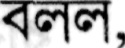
বলল,
